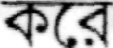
করে
